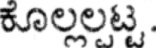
ಕೊಲ್ಲಲ್ಪಟ್ಟ.
